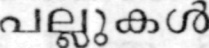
പല്ലുകള്‍
